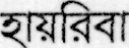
হায়রিবা
